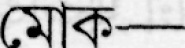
মোক-
